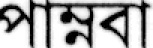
পাম্নবা
